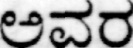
ಅವರ
